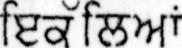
ਇਕੱਲਿਆਂ
